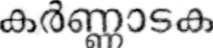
കര്‍ണ്ണാടക
